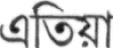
এতিয়া
